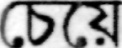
চেয়ে
